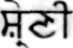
ਸ਼ੇਣੀ
